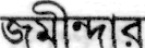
জমীন্দার
